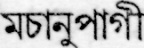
মচানুপাগী
